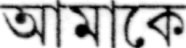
আমাকে
